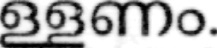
ള്ളണം.
